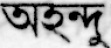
অহন্দু
